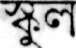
স্কুল
